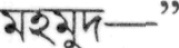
মহমুদ-"
